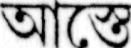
আস্তে
